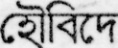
হৌবিদে
